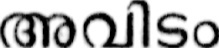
അവിടം
